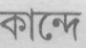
কান্দে
